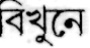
বিখুনে
